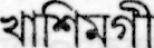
খাশিমগী
